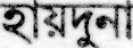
হায়দুনা
